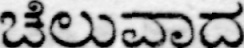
ಚೆಲುವಾದ
